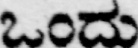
ಒಂದು
